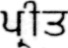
ਪ੍ਰੀਤ
